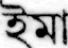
ইমা
